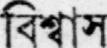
বিশ্বাস
